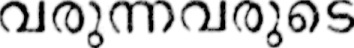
വരുന്നവരുടെ
